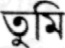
তুমি
